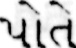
પોતે
